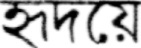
হৃদয়ে
